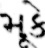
મૂકે
